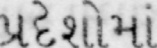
પ્રદેશોમાં
